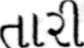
તારી
